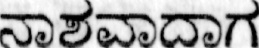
ನಾಶವಾದಾಗ
